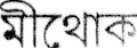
মীথোক
